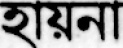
হায়না
